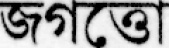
জগত্তো
